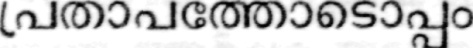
പ്രതാപത്തോടൊപ്പം
